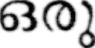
ഒരു
